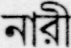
নারী
